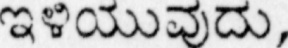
ಇಳಿಯುವುದು,
